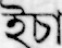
ইচা
